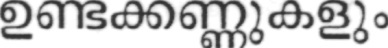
ഉണ്ടക്കണ്ണുകളും
